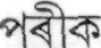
পৰীক
